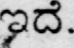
ಇದೆ.
